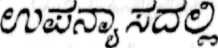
ಉಪನ್ಯಾಸದಲ್ಲಿ
